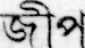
জীপ
